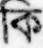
কি
